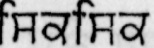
ਸਿਕਸਿਕ
